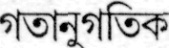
গতানুগতিক
